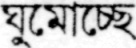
ঘুমোচ্ছে
